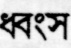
ধ্বংস
